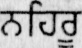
ਨਹਿਰੂ
